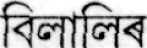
বিলালিৰ
